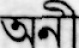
অনী
